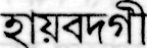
হায়বদগী
